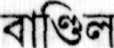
বাণ্ডিল
